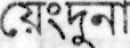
য়েংদুনা
